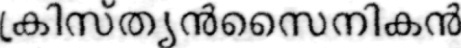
ക്രിസ്ത്യന്‍സൈനികന്‍
